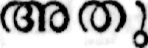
അതു
